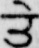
ਤੇ
